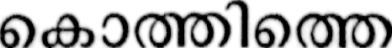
കൊത്തിത്തെ
